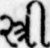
સ્ત્રી
